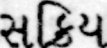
સક્રિય
